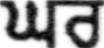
ਘਰ
